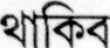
থাকিব
